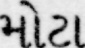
મોટા
